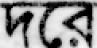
দরে
